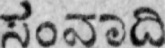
ಸಂವಾದಿ
